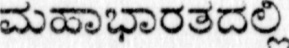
ಮಹಾಭಾರತದಲ್ಲಿ
